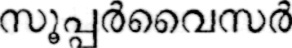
സൂപ്പര്‍വൈസര്‍
